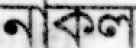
নাকল
